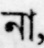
না,
